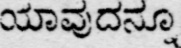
ಯಾವುದನ್ನೂ
